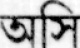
অসি
